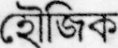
হৌজিক
